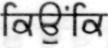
ਕਿਉਂਕਿ
